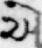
એ
